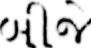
બીજે
